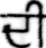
ਦੀ
